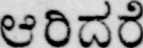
ಆರಿದರೆ
